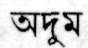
অদুম
